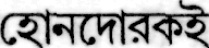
হোনদোরকই
